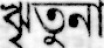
ঋৃতুনা
